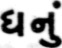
ધનું
